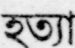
হত্যা
